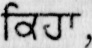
ਕਿਹਾ,
